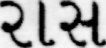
રાસ
